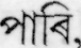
পাৰি,
